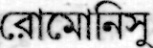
রোমোনিসু
